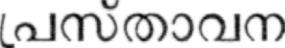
പ്രസ്താവന
